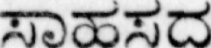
ಸಾಹಸದ
